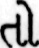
તો
